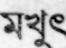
মখুৎ
